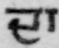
ਦਾ
